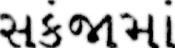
સકંજામાં
